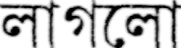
লাগলো
